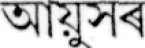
আয়ুসৰ
